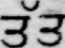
ਤੱਤ
